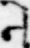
ને
